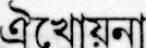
ঐখোয়না
